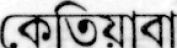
কেতিয়াবা
